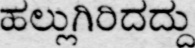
ಹಲ್ಲುಗಿರಿದದ್ದು
